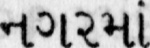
નગરમાં
